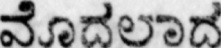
ಮೊದಲಾದ
